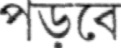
পড়বে
